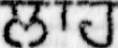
ਲਾਹ
